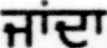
ਜਾਂਦਾ
